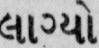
લાગ્યો
